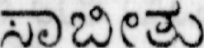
ಸಾಬೀತು
